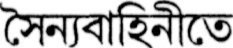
সৈন্যবাহিনীতে
